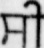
ਸੀ
